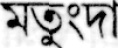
মতুংদা
